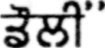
ਡੌਲੀ''
